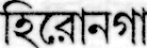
হিরোনগা
